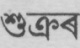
শুক্ৰৰ
